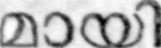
മായി
